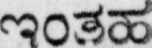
ಇಂತಹ
